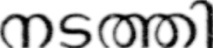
നടത്തി
